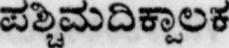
ಪಶ್ಚಿಮದಿಕ್ಪಾಲಕ
